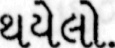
થયેલો.
